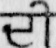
ਦੀ
